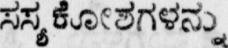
ಸಸ್ಯಕೋಶಗಳನ್ನು
